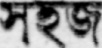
সহজ
